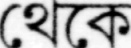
থেকে
